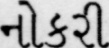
નોકરી
